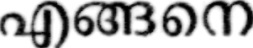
എങ്ങനെ
